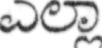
ಎಲ್ಲಾ
